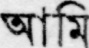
আমি
